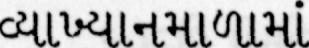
વ્યાખ્યાનમાળામાં
